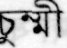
চুম্মী
